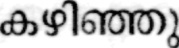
കഴിഞ്ഞു
